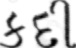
કદી
